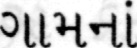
ગામનાં
